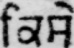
ਕਿਸੇ
